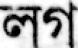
লগ
